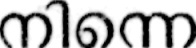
നിന്നെ
